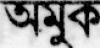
অমুক
